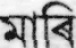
মাৰি
